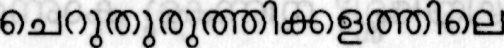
ചെറുതുരുത്തിക്കളത്തിലെ
